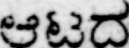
ಆಟದ
